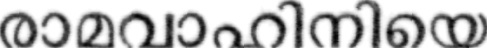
രാമവാഹിനിയെ
